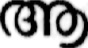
ആ
